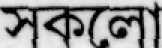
সকলো
